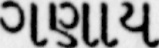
ગણાય
